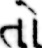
તો
